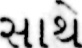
સાથે
